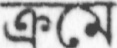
ক্রমে
